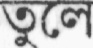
তুলে
